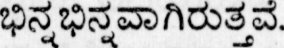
ಭಿನ್ನಭಿನ್ನವಾಗಿರುತ್ತವೆ.
